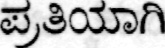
ಪ್ರತಿಯಾಗಿ
